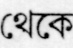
থেকে
